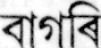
বাগৰি
